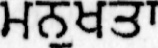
ਮਨੁਖਤਾ
